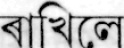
ৰাখিলে
